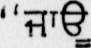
''ਜਾਊ
